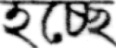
হচ্ছে
